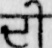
ਦੀ
